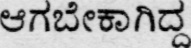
ಆಗಬೇಕಾಗಿದ್ದ
